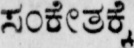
ಸಂಕೇತಕ್ಕೆ
